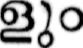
ളും
